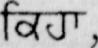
ਕਿਹਾ,
